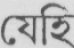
যেহি
